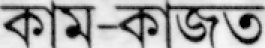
কাম-কাজত
